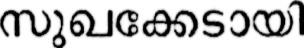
സുഖക്കേടായി
